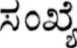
ಸಂಖ್ಯೆ
